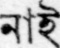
নাই
